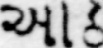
આઠ
